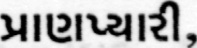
પ્રાણપ્યારી,
